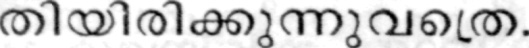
തിയിരിക്കുന്നുവത്രെ.
